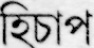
হিচাপ
